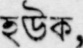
হউক,
